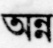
অন্ন
